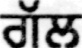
ਗੱਲ
